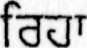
ਰਿਹਾ
